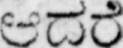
ಆದರೆ
